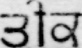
ਤੀਕ
